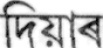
দিয়াৰ
